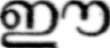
ഈ
